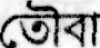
তৌবা
